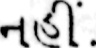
નહીં.
